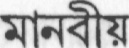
মানবীয়
